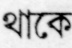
থাকে
